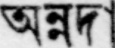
অন্নদা
